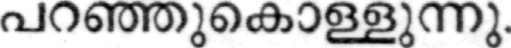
പറഞ്ഞുകൊള്ളുന്നു.
